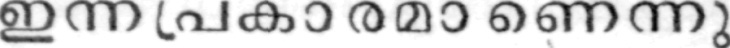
ഇന്നപ്രകാരമാണെന്നു
